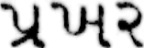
પ્રખર
